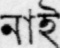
নাই
